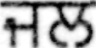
ਜਲ
